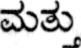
ಮತ್ತು
